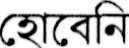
হোবেনি
